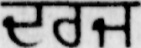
ਦਰਜ
